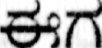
ಈಗ
